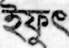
ইফুৎ
